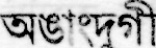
অঙাংদুগী
